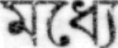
মধ্যে
